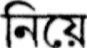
নিয়ে
